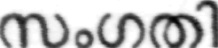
സംഗതി
